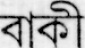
বাকী
